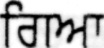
ਗਿਆ
